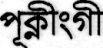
পূক্নীংগী
